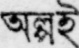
অল্পই
